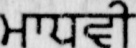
ਮਾਧਵੀ
